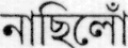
নাছিলোঁ
